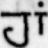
ਹਾਂ
